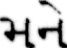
મને
